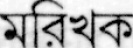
মরিখক
